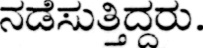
ನಡೆಸುತ್ತಿದ್ದರು.
